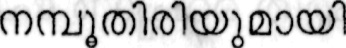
നമ്പൂതിരിയുമായി
